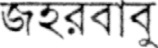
জহরবাবু
